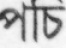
পচি
